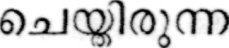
ചെയ്തിരുന്ന
